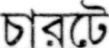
চারটে
